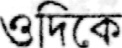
ওদিকে
